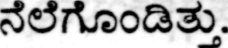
ನೆಲೆಗೊಂಡಿತ್ತು.
